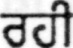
ਰਹੀ
